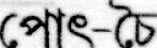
পোৎ-চৈ
